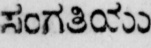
ಸಂಗತಿಯು
